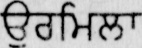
ਉਰਮਿਲਾ
